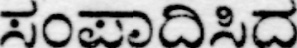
ಸಂಪಾದಿಸಿದ
